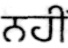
ਨਹੀਂ
